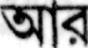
আর
